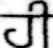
ਹੀ
